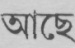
আছে
